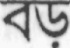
বড়
